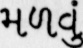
મળવું
